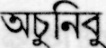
অচুনিবু
